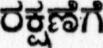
ರಕ್ಷಣೆಗೆ
